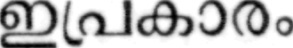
ഇപ്രകാരം
